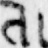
તો
